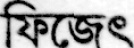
ফিজেৎ
